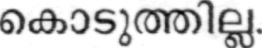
കൊടുത്തില്ല.
